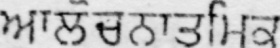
ਆਲੋਚਨਾਤਮਿਕ
